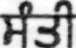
ਸੰਤੀ
